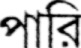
পারি
